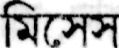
মিসেস
